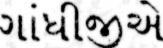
ગાંધીજીએ
